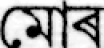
মোৰ
